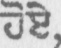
ਹੋਏ,
